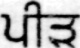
ਪੀੜ
